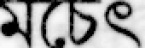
মচেৎ
